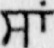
ਸਾਂ
